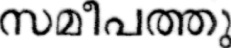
സമീപത്തു
